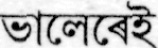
ভালেৰেই
